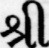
શ્રી
